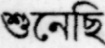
শুনেছি
